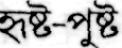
হৃষ্ট-পুষ্ট
